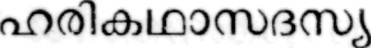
ഹരികഥാസദസ്യ
